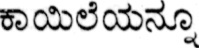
ಕಾಯಿಲೆಯನ್ನೂ
